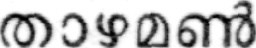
താഴമണ്‍
